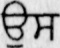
ਉਸ
